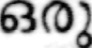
ഒരു
